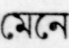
মেনে
